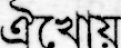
ঐখোয়
